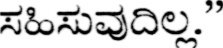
ಸಹಿಸುವುದಿಲ್ಲ."
